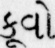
કૂવો
